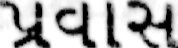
પ્રવાસ
